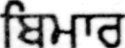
ਬਿਮਾਰ
